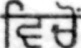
ਵਿਚੋਂ
